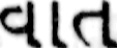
વાત
